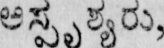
ಅಸ್ಪೃಶ್ಯರು,
